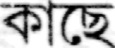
কাছে
